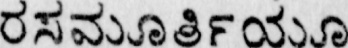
ರಸಮೂರ್ತಿಯೂ
